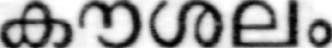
കൌശലം
